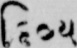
દિવ્ય
